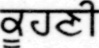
ਕੂਹਣੀ
